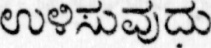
ಉಳಿಸುವುದು
